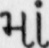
માં
